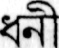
ধনী
